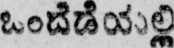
ಒಂದೆಡೆಯಲ್ಲಿ
